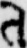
તે
